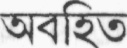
অবহিত
